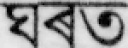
ঘৰত
